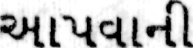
આપવાની
